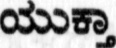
ಯುಕ್ತಾ
